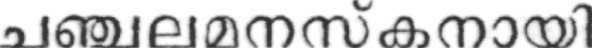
ചഞ്ചലമനസ്കനായി
